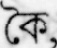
কৈ,
